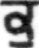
ਕੁ
